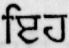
ਇਹ
